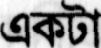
একটা
